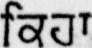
ਕਿਹਾ
